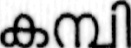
കമ്പി
